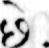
છે.
